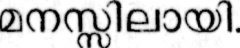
മനസ്സിലായി.
